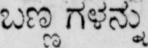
ಬಣ್ಣಗಳನ್ನು
